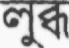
লুব্ধ
